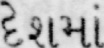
દેશમાં
